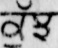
ਕੁੱਝ
